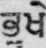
ਭੂਖੇ
